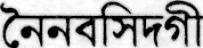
নৈনবসিদগী
